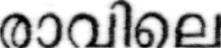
രാവിലെ
